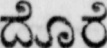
ದೊರೆ
